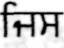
ਜਿਸ
